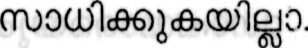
സാധിക്കുകയില്ലാ.
